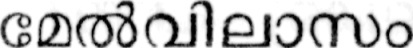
മേല്‍വിലാസം
